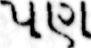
પણ
